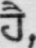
ਹੈ,
